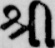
શ્રી
